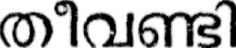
തീവണ്ടി
